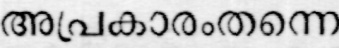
അപ്രകാരംതന്നെ
